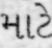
માટે
